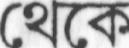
থেকে
